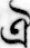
ঐ
